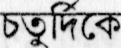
চতুর্দিকে
